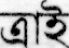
ত্রাই
